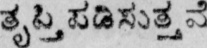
ತೃಪ್ತಿಪಡಿಸುತ್ತವೆ
